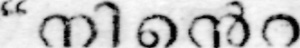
"നിന്റെ
